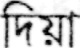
দিয়া
